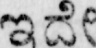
ಇದೇ
